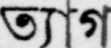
ত্যাগ
